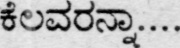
ಕೆಲವರನ್ನಾ.......
